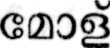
മോള്
